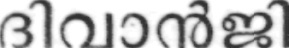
ദിവാന്‍ജി
